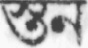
স্তন
